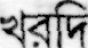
খরদি
